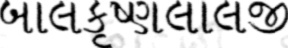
બાલકૃષ્ણલાલજી
